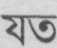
যত
